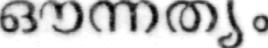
ഔന്നത്യം
